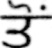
ਤੋਂ
